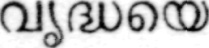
വൃദ്ധയെ
